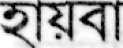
হায়বা
